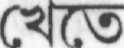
খেতে
